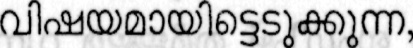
വിഷയമായിട്ടെടുക്കുന്ന,
